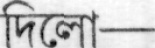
দিলো-
